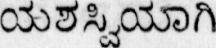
ಯಶಸ್ವಿಯಾಗಿ
